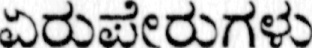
ಏರುಪೇರುಗಳು
